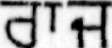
ਰਾਜ
